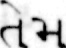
તેમ
